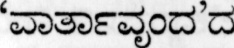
‘ವಾರ್ತಾವೃಂದ’ದ
